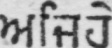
ਅਜਿਹੇ
